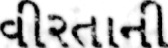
વીરતાની
